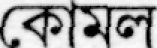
কোমল
